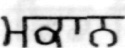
ਮਕਾਨ
